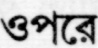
ওপরে
